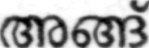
അങ്ങ്
